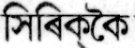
সিৰিক্‌কৈ
